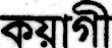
কয়াগী
